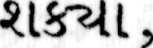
શક્યા,
